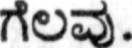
ಗೆಲುವು.
